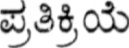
ಪ್ರತಿಕ್ರಿಯೆ
